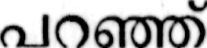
പറഞ്ഞ്
